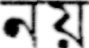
নয়
